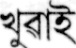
খুৱাই
